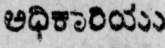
ಅಧಿಕಾರಿಯು
